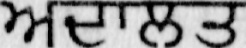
ਅਦਾਲਤ
